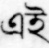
এই
